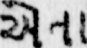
એના
